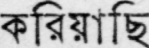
করিয়াছি
